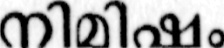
നിമിഷം
